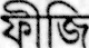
ফীজি
